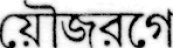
য়ৌজরগে
